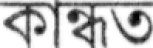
কান্ধত
